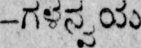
-ಗಳನ್ವಯ
